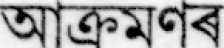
আক্রমণৰ
